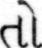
તો
